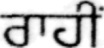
ਰਾਹੀਂ
